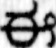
ಈ
